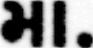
મા.
